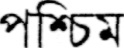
পশ্চিম
